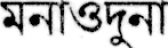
মনাওদুনা
